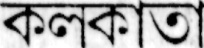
কলকাতা
